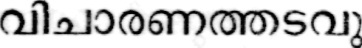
വിചാരണത്തടവു
